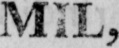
MIL,
